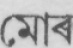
মোৰ
